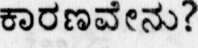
ಕಾರಣವೇನು?
